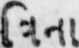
વિના
